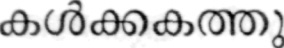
കള്‍ക്കകത്തു
